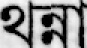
থন্না
